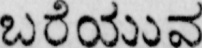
ಬರೆಯುವ
